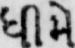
ધીમે
